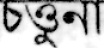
চত্তুনা
